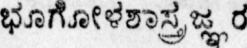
ಭೂಗೋಳಶಾಸ್ತ್ರಜ್ಞರ
